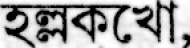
হল্লকখো,
